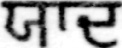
ਯਾਦ
